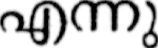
എന്നു
